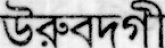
উরুবদগী
